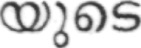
യുടെ
